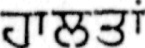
ਹਾਲਤਾਂ
